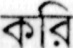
করি
